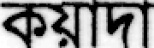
কয়াদা
